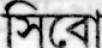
সিবো
